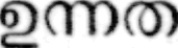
ഉന്നത
